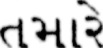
તમારે
